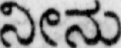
ನೀನು
